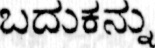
ಬದುಕನ್ನು
